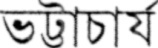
ভট্টাচার্য
